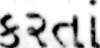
કરતાં
